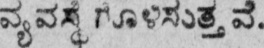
ವ್ಯವಸ್ಥೆಗೂಳಿಸುತ್ತವೆ.
